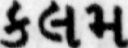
કલમ
